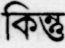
কিন্তু
